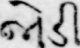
જોડી
